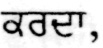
ਕਰਦਾ,
